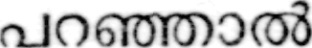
പറഞ്ഞാല്‍
